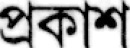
প্রকাশ
